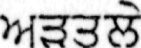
ਅੜਤਲੇ
